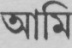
আমি
